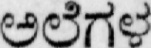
ಅಲೆಗಳ
